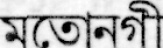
মতোনগী
